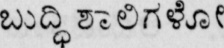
ಬುದ್ಧಿಶಾಲಿಗಳೋ
